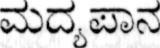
ಮದ್ಯಪಾನ
